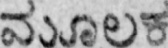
ಮೂಲಕ
